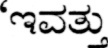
'ಇವತ್ತು
